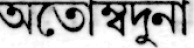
অতোম্বদুনা
